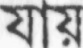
যায়
